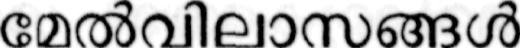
മേല്‍വിലാസങ്ങള്‍
